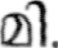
മി.
